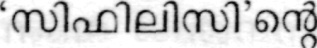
'സിഫിലിസി'ന്റെ
